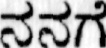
ನನಗೆ
